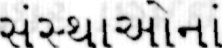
સંસ્થાઓનાં
